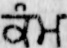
ਕੰਮ
